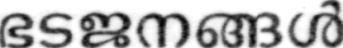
ഭടജനങ്ങള്‍
